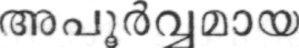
അപൂര്‍വ്വമായ
